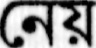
নেয়
